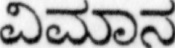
ವಿಮಾನ
